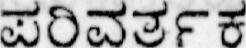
ಪರಿವರ್ತಕ
